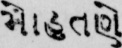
મોહતણે
